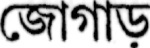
জোগাড়
